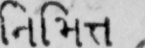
નિમિત્ત,
